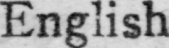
English
